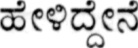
ಹೇಳಿದ್ದೇನೆ
